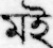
মই
